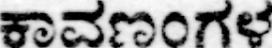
ಕಾವಣಂಗಳ
